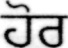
ਹੋਰ
